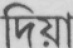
দিয়া
